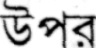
উপর
